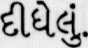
દીધેલું.
